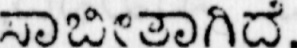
ಸಾಬೀತಾಗಿದೆ.
